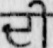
ਦੀ
